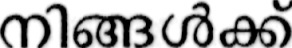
നിങ്ങള്‍ക്ക്
